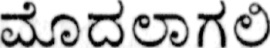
ಮೊದಲಾಗಲಿ
